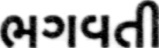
ભગવતી
